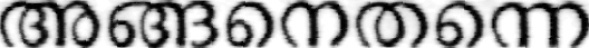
അങ്ങനെതന്നെ
